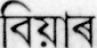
বিয়াৰ
